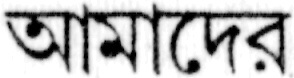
আমাদের
